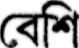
বেশি
